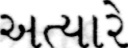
અત્યારે
